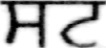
ਸਟ
